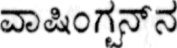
ವಾಷಿಂಗ್ಟನ್ ನ
